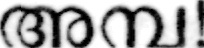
അമ്പ!
